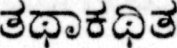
ತಥಾಕಥಿತ
